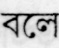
বলে
